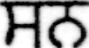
ਸਨ
